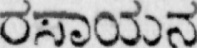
ರಸಾಯನ
